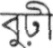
বুঢ়ী
